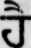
ਹੈ
